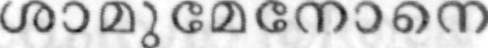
ശാമുമേനോനെ
